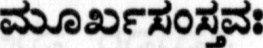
ಮೂರ್ಖಸಂಸ್ತವಃ
